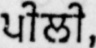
ਪੀਲੀ,
